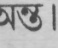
অন্ত
